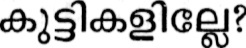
കുട്ടികളില്ലേ?
